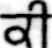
ਕੀ
